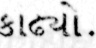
કાઢ્યો.
